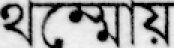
থম্মোয়
